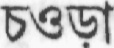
চওড়া
